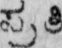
ಪ್ರತಿ
